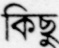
কিছু
